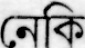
নেকি
